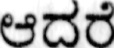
ಆದರೆ
